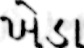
ખેડા
